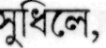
সুধিলে,
